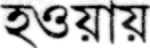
হওয়ায়
